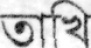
তাখি
